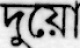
দুয়ো
